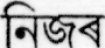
নিজৰ
